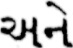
અને
